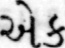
એક
